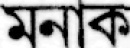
মনাক
